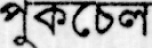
পুকচেল
